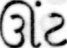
ઊંટ
